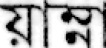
য়াম্না
